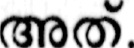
അത്.
